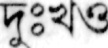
দুঃখও
